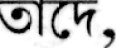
তাদে,
